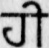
ਹੀ
